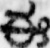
ಈ
